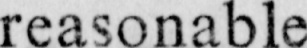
reasonable
